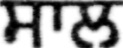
ਸਾਲ
